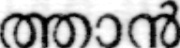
ത്താന്‍
